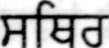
ਸਥਿਰ
